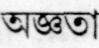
অজ্ঞতা
